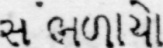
સંભળાયો
